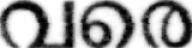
വരെ
